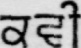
ਕਵੀ
